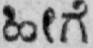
ಹೀಗೆ
